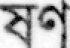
ষণ
